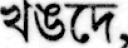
খঙদে,
